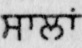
ਸਾਲਾਂ
